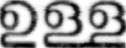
ഉള്ള
